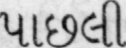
પાછલી
